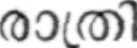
രാത്രി
